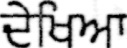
ਦੇਖਿਆ
